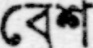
বেশ
